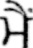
ਮੈਂ
